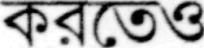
করতেও
